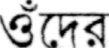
ওঁদের
